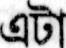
এটা
